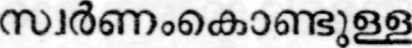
സ്വര്‍ണംകൊണ്ടുള്ള
